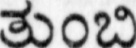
ತುಂಬಿ
